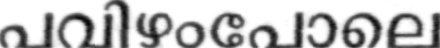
പവിഴംപോലെ
